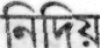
নিদিয়
